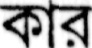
কার
